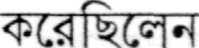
করেছিলেন
